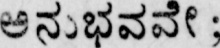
ಅನುಭವವೇ;
